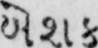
બેશક
